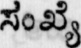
ಸಂಖ್ಯೆ
